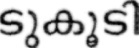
ടുകൂടി
